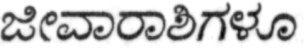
ಜೀವರಾಶಿಗಳೂ
